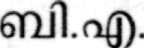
ബി.എ.
